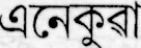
এনেকুৱা
